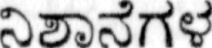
ನಿಶಾನೆಗಳ
